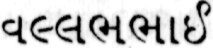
વલ્લભભાઈ
